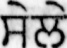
ਸੇਲੇ
